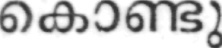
കൊണ്ടു
